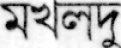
মখলদু
